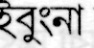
ইবুংনা
